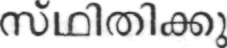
സ്ഥിതിക്കു
